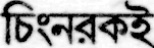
চিংনরকই
